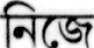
নিজে
